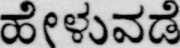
ಹೇಳುವಡೆ
